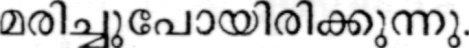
മരിച്ചുപോയിരിക്കുന്നു.
